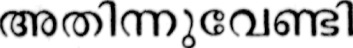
അതിന്നുവേണ്ടി
